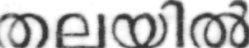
തലയില്‍
